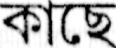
কাছে
